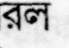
রল
